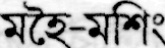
মহৈ-মশিং
